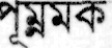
পূম্নমক
